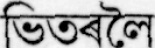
ভিতৰলৈ
